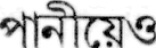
পানীয়েও
